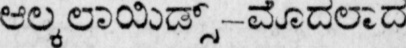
ಆಲ್ಕಲಾಯಿಡ್ಸ್-ಮೊದಲಾದ
